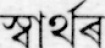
স্বার্থৰ
